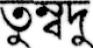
তুম্বদু
